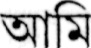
আমি
